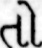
તો
